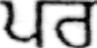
ਪਰ
